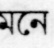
মনে
